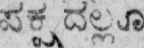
ಪಕ್ಷದಲ್ಲೂ
